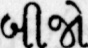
બીજો
